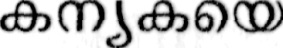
കന്യകയെ
